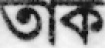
তাক
